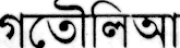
গতৌলিআ
